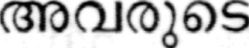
അവരുടെ
